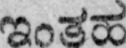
ಇಂತಹ
